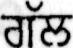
ਗੱਲ
